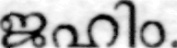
ജഹിം.
